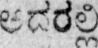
ಅದರಲ್ಲಿ
